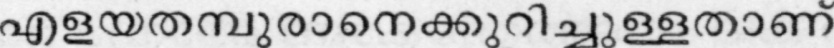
എളയതമ്പുരാനെക്കുറിച്ചുള്ളതാണ്
